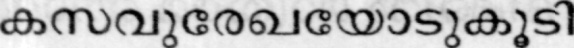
കസവുരേഖയോടുകൂടി
